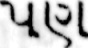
પણ
